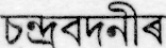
চন্দ্রবদনীৰ
